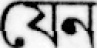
যেন
